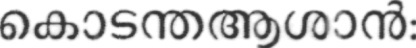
കൊടന്തആശാന്‍:
